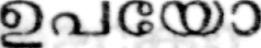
ഉപയോ
